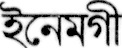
ইনেমগী
